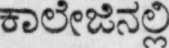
ಕಾಲೇಜಿನಲ್ಲಿ
